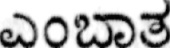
ಎಂಬಾತ
